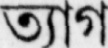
ত্যাগ
